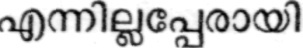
എന്നില്ലപ്പേരായി
